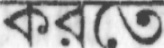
করতে
